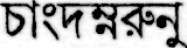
চাংদম্নরুনু
